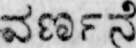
ವರ್ಣನೆ
